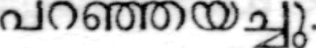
പറഞ്ഞയച്ചു.
